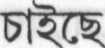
চাইছে
